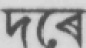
দৰে
